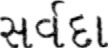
સર્વદા
